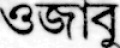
ওজাবু
